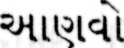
આણવો
